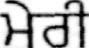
ਮੇਰੀ
